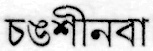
চঙশীনবা
